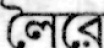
লৈরে
